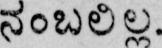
ನಂಬಲಿಲ್ಲ.
